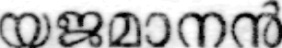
യജമാനന്‍
